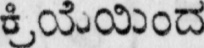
ಕ್ರಿಯೆಯಿಂದ
